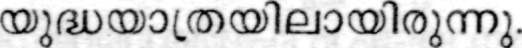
യുദ്ധയാത്രയിലായിരുന്നു.
